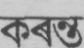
কৰন্ত
